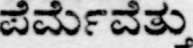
ಪೆರ್ಮೆವೆತ್ತು
